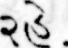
રહે.
